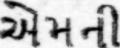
એમની
